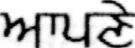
ਆਪਣੇ
